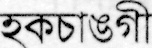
হকচাঙগী
